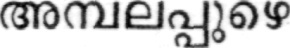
അമ്പലപ്പുഴെ
